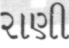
રાણી
